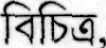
বিচিত্র,
